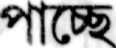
পাচ্ছে
